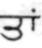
ਤਾਂ
